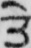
ਤੇ
